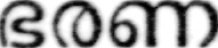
ഭരണ
